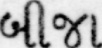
બીજા
